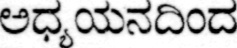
ಅಧ್ಯಯನದಿಂದ
